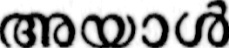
അയാള്‍
